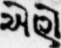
એણે
